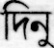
দিনু
